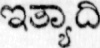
ಇತ್ಯಾದಿ
